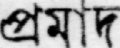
প্রমাদ
